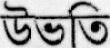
উভতি
